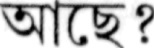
আছে?
